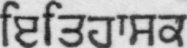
ਇਤਿਹਾਸਕ
